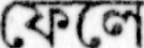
ফেলে
